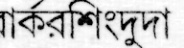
ৱার্করশিংদুদা
